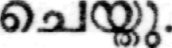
ചെയ്തു.
